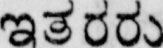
ಇತರರು
